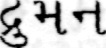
દ્રુમન
